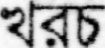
খরচ
